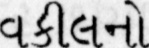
વકીલનો
